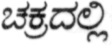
ಚಕ್ರದಲ್ಲಿ
